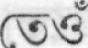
তেওঁ
